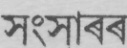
সংসাৰৰ
